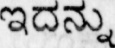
ಇದನ್ನು
